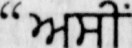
''ਅਸੀਂ
